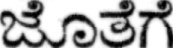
ಜೊತೆಗೆ
